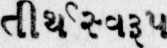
તીર્થસ્વરૂપ
